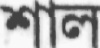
শাল
